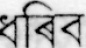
ধৰিব
